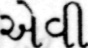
એવી
